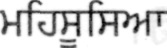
ਮਹਿਸੂਸਿਆ
